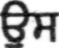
ਉਸ
